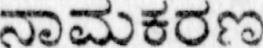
ನಾಮಕರಣ
